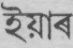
ইয়াৰ
